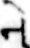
ને
